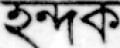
হন্দক
